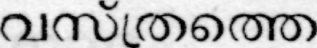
വസ്ത്രത്തെ
